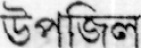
উপজিল
